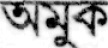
অমুক
